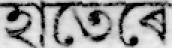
হাতেৰে
